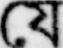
যে
